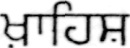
ਖ਼ਾਹਿਸ਼
